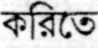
করিতে
